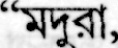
“মদুরা,
